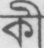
কী
